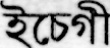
ইচেগী
